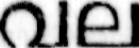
വല
